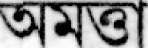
অমত্তা
